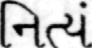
નિત્યં
